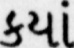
કયાં
